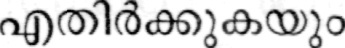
എതിര്‍ക്കുകയും
